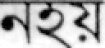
নহয়
